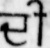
ਦੀ
